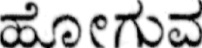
ಹೋಗುವ
